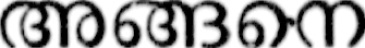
അങ്ങനെ
